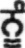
ਨੂੰ
